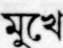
মুখে
